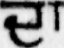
ਦਾ
